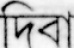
দিবা
